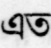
এত
